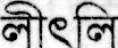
লীৎলি
